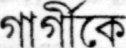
গার্গীকে
